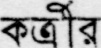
কর্ত্রীর
